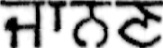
ਜਾਨਣ
